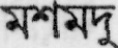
মশমদু
